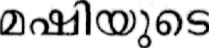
മഷിയുടെ
